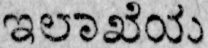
ಇಲಾಖೆಯ್
